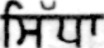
ਸਿੱਧਾ
